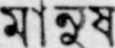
মানুষ
